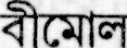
বীমোল
